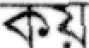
কয়
